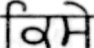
ਕਿਸੇ
